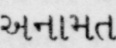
અનામત
